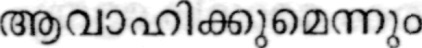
ആവാഹിക്കുമെന്നും
